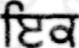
ਇਕ
